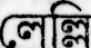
লেল্লি
